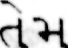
તેમ
